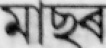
মাছৰ
